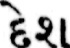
દેશ
